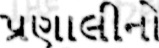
પ્રણાલીનો
